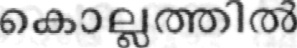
കൊല്ലത്തില്‍
